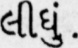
લીધું.
